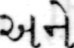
અને
